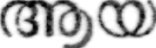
ആയ
